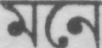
মনে
